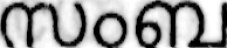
സംബ
